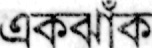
একঝাঁক
